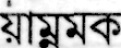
য়াম্নমক
